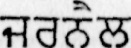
ਜਰਨੈਲ
